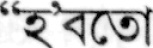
"হ'বতো
